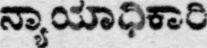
ನ್ಯಾಯಾಧಿಕಾರಿ
